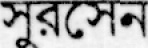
সুরসেন
